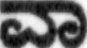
ವಾ
